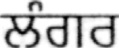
ਲੰਗਰ
